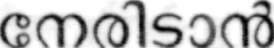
നേരിടാന്‍
